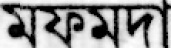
মফমদা
